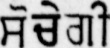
ਸੋਚੇਗੀ
